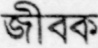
জীবক
